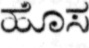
ಹೊಸ
